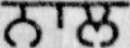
ਨਾਲ
